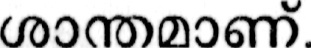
ശാന്തമാണ്.
